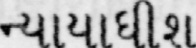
ન્યાયાધીશ
